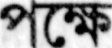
পক্ষে
